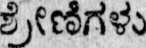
ಶ್ರೇಣಿಗಳು
